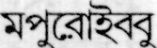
মপুরোইববু
